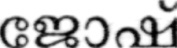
ജോഷ്
